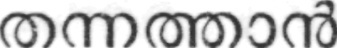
തന്നത്താന്‍
